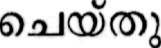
ചെയ്തു
